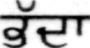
ਭੱਦਾ
